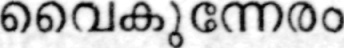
വൈകുന്നേരം
